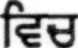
ਵਿਚ
